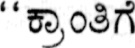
"ಕ್ರಾಂತಿಗೆ
